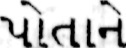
પોતાને
